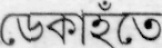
ডেকাহঁতে
